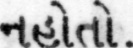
નહોતો.
